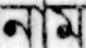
নাম
